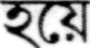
হয়ে
